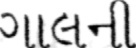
ગાલની
